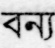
বন্য
